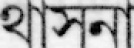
থাসনা
